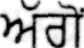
ਅੱਗੋਂ
